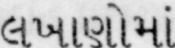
લખાણોમાં
